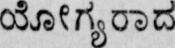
ಯೋಗ್ಯರಾದ
